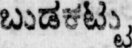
ಬುಡಕಟ್ಟು
